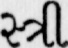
સ્ત્રી
